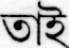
তাই
